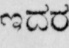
ಇದರ
